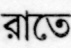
রাতে
